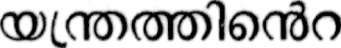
യന്ത്രത്തിന്റെ
